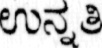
ಉನ್ನತಿ
